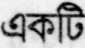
একটি
